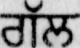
ਗੱਲ
